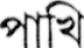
পাখি
